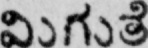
ಮಿಗುತೆ
